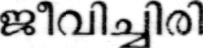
ജീവിച്ചിരി
